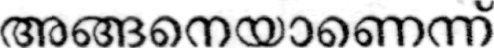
അങ്ങനെയാണെന്ന്
